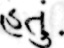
હતું.
